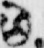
છે.
